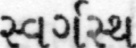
સ્વર્ગસ્થ
